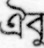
ঐবু
